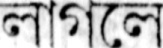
লাগলে
